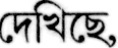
দেখিছে,
